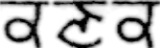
ਕਣਕ
